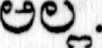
ಅಲ್ಲ.
